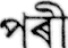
পৰী
